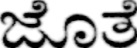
ಜೊತೆ
